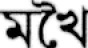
মখৈ
